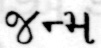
જન્મ
